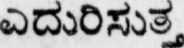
ಎದುರಿಸುತ್ತ
